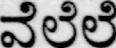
ವೆಲೆಲೆ
